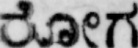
ರೋಗ
